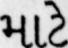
માટે
